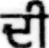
ਦੀ
